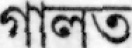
গালত
